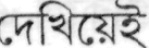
দেখিয়েই
